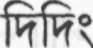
দিদিং
